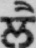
ਲੈ
